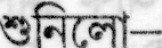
শুনিলো-
